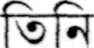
তিনি
